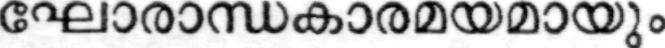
ഘോരാന്ധകാരമയമായും
